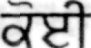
ਕੋਈ
